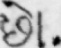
છો.
